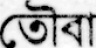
তৌবা
